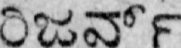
ರಿಜರ್ವ್
